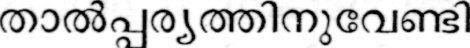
താല്‍പ്പര്യത്തിനുവേണ്ടി
